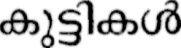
കുട്ടികള്‍
